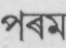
পৰম
